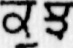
ਕੁਝ
